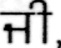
ਜੀ,
